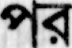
পর
